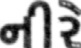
નીરે
